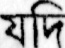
যদি
